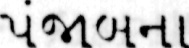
પંજાબના
